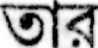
তার
